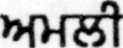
ਅਮਲੀ
